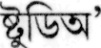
ষ্টুডিঅ'
